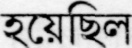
হয়েছিল
